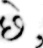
છે,
